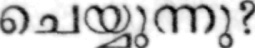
ചെയ്യുന്നു?
